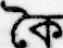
কৈ
